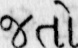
જતો
